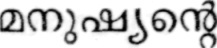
മനുഷ്യന്റെ
